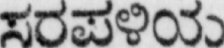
ಸರಪಳಿಯ
